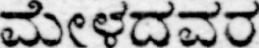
ಮೇಳದವರ
